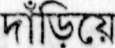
দাঁড়িয়ে
